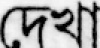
দেখা
